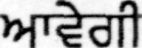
ਆਵੇਗੀ
